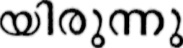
യിരുന്നു
